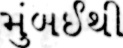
મુંબઈથી
